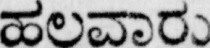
ಹಲವಾರು
